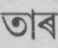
তাৰ
